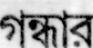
গন্ধার
